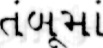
તંબૂમાં
